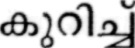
കുറിച്ച്
